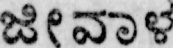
ಜೀವಾಳ
